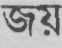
জয়
